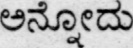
ಅನ್ನೋದು
